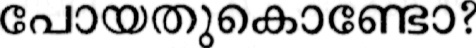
പോയതുകൊണ്ടോ?
